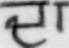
ਦਾ
